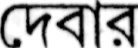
দেবার
